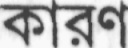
কারণ
